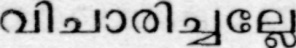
വിചാരിച്ചല്ലേ
